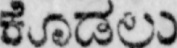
ಕೊಡಲು
